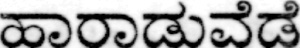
ಹಾರಾಡುವೆಡೆ
